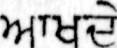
ਆਖਦੇ
